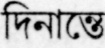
দিনান্তে
